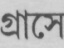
গ্ৰাসে
